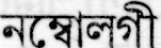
নম্বোলগী
